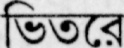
ভিতরে
